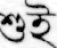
শুই
